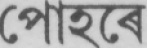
পোহৰে
